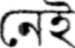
নেই
